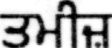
ਤਮੀਜ਼
